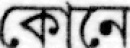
কোনে
